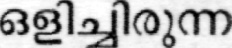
ഒളിച്ചിരുന്ന
